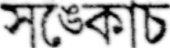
সঙ্কোচ
